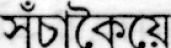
সঁচাকৈয়ে
